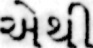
એથી
